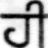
ਹੀ
